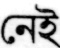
নেই
